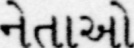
નેતાઓ
